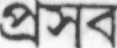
প্রসব
